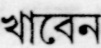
খাবেন
